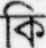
কি
